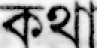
কথা
